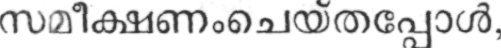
സമീക്ഷണംചെയ്തപ്പോള്‍,
